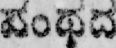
ಪಂಥದ
